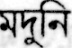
মদুনি
